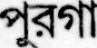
পুরগা
